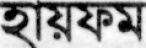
হায়ফম
